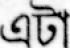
এটা
